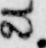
ವ.
